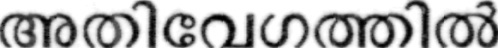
അതിവേഗത്തില്‍
